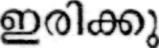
ഇരിക്കു
